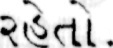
રહેતો.
